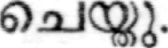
ചെയ്തു.
